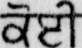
ਕੋਈ
